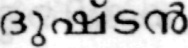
ദുഷ്ടന്‍
